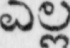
ಎಲ್ಲ
